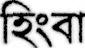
হিংবা
